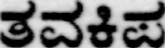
ತವಕಿಪ
